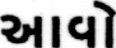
આવો
